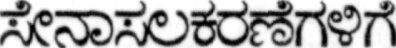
ಸೇನಾಸಲಕರಣೆಗಳಿಗೆ
